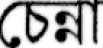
চেন্না
